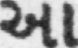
આ
